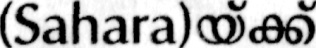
(Sahara)യ്ക്ക്
